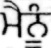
ਮੈਨੂੰ
